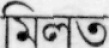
মিলত
